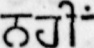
ਨਹੀਂ
